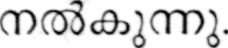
നല്‍കുന്നു.
